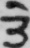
ਤੇ
